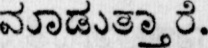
ಮಾಡುತ್ತಾರೆ.
